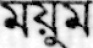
ময়ুম
